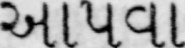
આપવા
